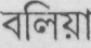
বলিয়া
